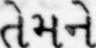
તેમને
